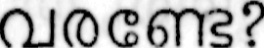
വരണ്ടേ?
